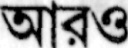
আরও
